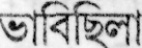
ভাবিছিলা
